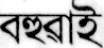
বহুৱাই
